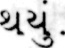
થયું.
